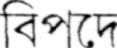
বিপদে
